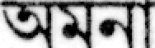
অমনা
